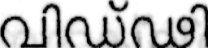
വിഡ്ഢി
